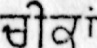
ਚੀਕਾਂ
